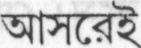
আসরেই
